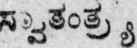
ಸ್ವಾತಂತ್ರ್ಯ
